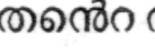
തൻെറ
